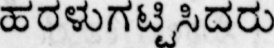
ಹರಳುಗಟ್ಟಿಸಿದರು
